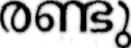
രണ്ടു
